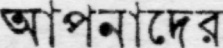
আপনাদের
